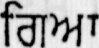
ਗਿਆ
